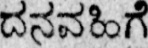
ದನವಹಿಗೆ
